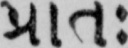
પ્રાતઃ
